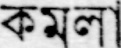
কমলা
